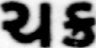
ચક્ર
